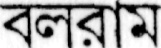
বলরাম
